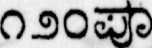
೧೨೦ಪೂ
